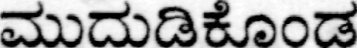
ಮುದುಡಿಕೊಂಡ
